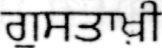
ਗੁਸਤਾਖ਼ੀ
